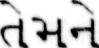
તેમને
